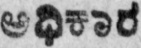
ಅಧಿಕಾರ
